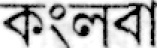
কংলবা
